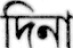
দিনা
